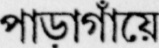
পাড়াগাঁয়ে
